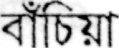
বাঁচিয়া
